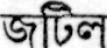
জটিল
